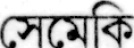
সেমেকি
